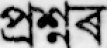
প্রশ্নৰ
